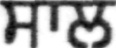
ਸਾਲ
